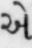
એ
